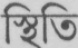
স্থিতি
